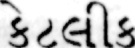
કેટલીક
